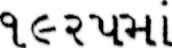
૧૯૨૫માં
